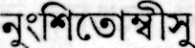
নুংশিতোম্বীসু
